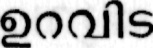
ഉറവിട
